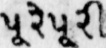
પૂરેપૂરી
